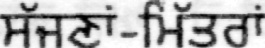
ਸੱਜਣਾਂ-ਮਿੱਤਰਾਂ
